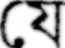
যে
